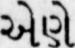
એણે
